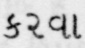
કરવા
